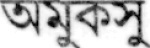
অমুকসু
